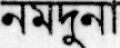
নমদুনা
